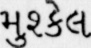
મુશ્કેલ
